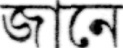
জানে
